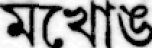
মখোঙ
